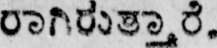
ರಾಗಿರುತ್ತಾರೆ.
